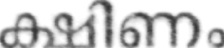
ക്ഷിണം
